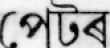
পেটৰ
